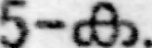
5-ക.
